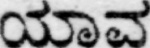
ಯಾವ
